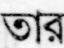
তার
